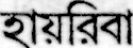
হায়রিবা
